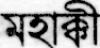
মহাক্কী
